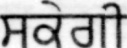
ਸਕੇਗੀ
